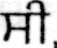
ਸੀ।
